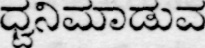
ಧ್ವನಿಮಾಡುವ
